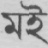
মই
